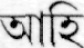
আহি
